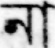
না
